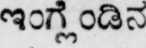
ಇಂಗ್ಲೆಂಡಿನ
